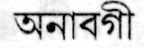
অনাবগী
